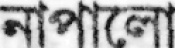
নাপালো
